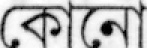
কোনো
